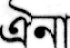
ঐনা
